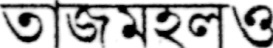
তাজমহলও
